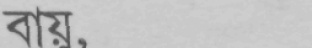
বায়ু,
